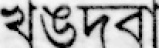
খঙদবা
